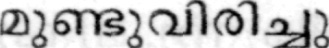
മുണ്ടുവിരിച്ചു
